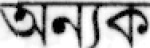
অন্যক
